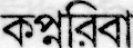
কপ্নরিবা
